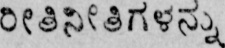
ರೀತಿನೀತಿಗಳನ್ನು
